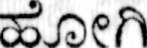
ಹೋಗಿ
